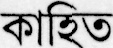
কাহিত
